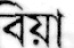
বিয়া
